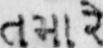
તમારે
